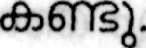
കണ്ടു.
